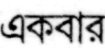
একবার
